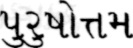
પુરુષોત્તમ
